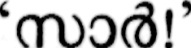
‘സാര്‍!'
